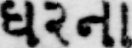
ઘરના
